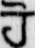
ਹੋ
